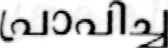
പ്രാപിച്ച
